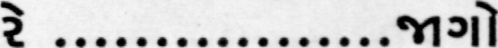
રે...........જાગો
